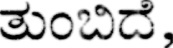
ತುಂಬಿದೆ,
